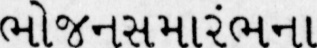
ભોજનસમારંભના
